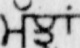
ਮੱਝਾਂ
